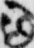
છે
